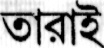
তারাই
